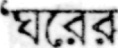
‘ঘরের
